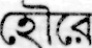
হৌরে
